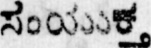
ಸಂಯುಕ್ತ
